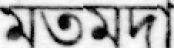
মতমদা
